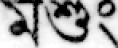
মশুং
